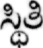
ಸ್ಥಿತಿ
